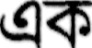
এক
